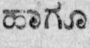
ಹಾಗೂ
